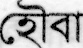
হৌবা
